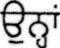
ਉਨ੍ਹਾਂ
